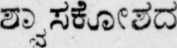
ಶ್ವಾಸಕೋಶದ
